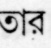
তার
